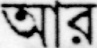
আর
